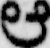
ಆ
